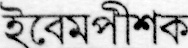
ইবেমপীশক
